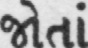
જોતાં
